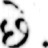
છે.
